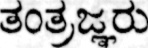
ತಂತ್ರಜ್ಞರು
